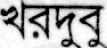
খরদুসু
